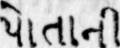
પોતાની
